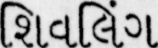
શિવલિંગ
